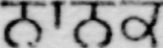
ਨਾਨਕ
